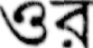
ওর
